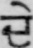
ਦੇ
